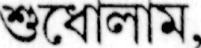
শুধোলাম,
